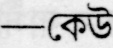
–কেউ
